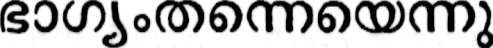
ഭാഗ്യംതന്നെയെന്നു
